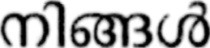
നിങ്ങള്‍
